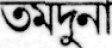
তমদুনা
